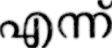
എന്ന്
